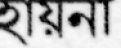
হায়না
